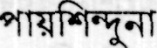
পায়শিন্দুনা
